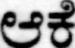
ಆಕೆ
